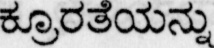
ಕ್ರೂರತೆಯನ್ನು
